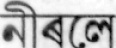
নীৰলে
